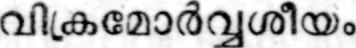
വിക്രമോര്‍വ്വശീയം
